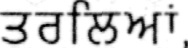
ਤਰਲਿਆਂ,
